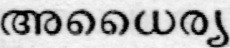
അധൈര്യ
